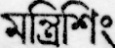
মন্ত্রিশিং
